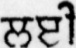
ਲਈ
